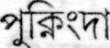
পুক্নিংদা
